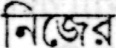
নিজের
